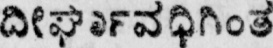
ದೀರ್ಘಾವಧಿಗಿಂತ
